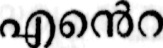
എന്റെ
